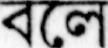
বলে
